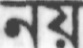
নয়
